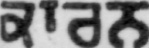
ਕਾਰਨ
